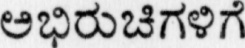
ಅಭಿರುಚಿಗಳಿಗೆ
